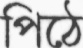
পিঠে
